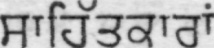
ਸਾਹਿੱਤਕਾਰਾਂ
